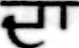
ਦਾ
